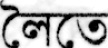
লৈতে
